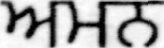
ਅਮਨ
